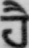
ਹੈ
